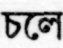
চলে
